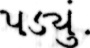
પડ્યું.
